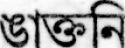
ঙাক্তনি
